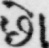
છો
